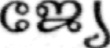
ജ്യേ
